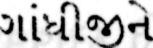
ગાંધીજીને
